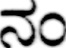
ನಂ
